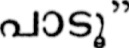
പാടൂ”
